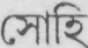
সোহি
